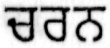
ਚਰਨ
